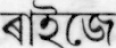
ৰাইজে
